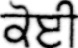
ਕੋਈ
